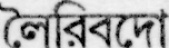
লৈরিবদো
